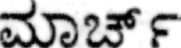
ಮಾರ್ಚ್
